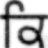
ਕਿ
